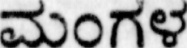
ಮಂಗಳ
